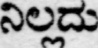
ನಿಲ್ಲದು
